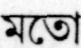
মতো
